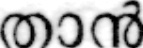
താന്‍
